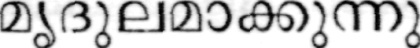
മൃദുലമാക്കുന്നു
